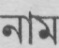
নাম
